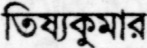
তিষ্যকুমার
